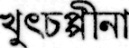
খুৎচপ্পীনা
